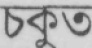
চকুত
